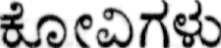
ಕೋವಿಗಳು
